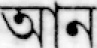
আন
